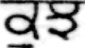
'ਕੁਝ
